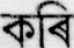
কৰি
